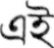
এই
